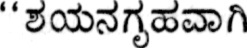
"ಶಯನಗೃಹವಾಗಿ
